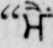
''ਮੈਂ
